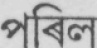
পৰিল
